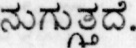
ನುಗ್ಗುತ್ತದೆ.
